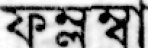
ফম্লম্বা
